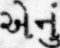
એનું
